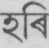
হৰি
